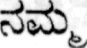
ನಮ್ಮ
